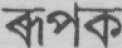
ৰূপক
